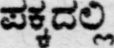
ಪಕ್ಕದಲ್ಲಿ
